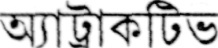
অ্যাট্রাকটিভ
